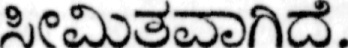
ಸೀಮಿತವಾಗಿದೆ.
